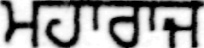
ਮਹਾਰਾਜ
